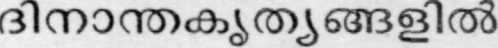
ദിനാന്തകൃത്യങ്ങളില്‍
